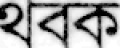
থবক
